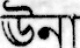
ঊনা
